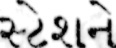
સ્ટેશને
